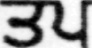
ਤਪ
